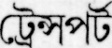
ট্রেন্সপৰ্ট
